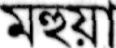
মহুয়া
